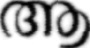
ആ
